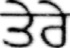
ਤੇਰੇ
